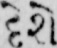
દેશે
